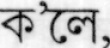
ক'লে,
